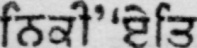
ਨਿਕੀ''ਏਤਿ
